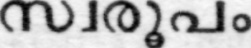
സ്വരൂപം
